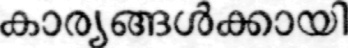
കാര്യങ്ങള്‍ക്കായി
